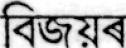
বিজয়ৰ
